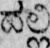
ದಲ್ಲಿ
